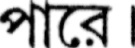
পারে।
